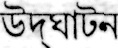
উদ্‌ঘাটন
